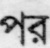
পর
